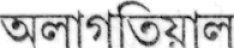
অলাগতিয়াল
